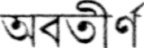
অবতীর্ণ
